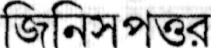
জিনিসপত্তর
